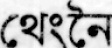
থেংনৈ
